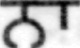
ਨਾ
